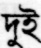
দুই
